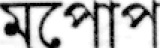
মপোপ
